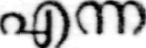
എന്ന
